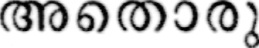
അതൊരു
